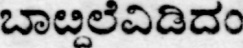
ಬಾೞ್ದಲೆವಿಡಿದಂ
